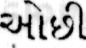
ઓછી
